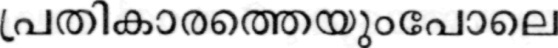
പ്രതികാരത്തെയുംപോലെ
